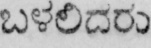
ಬಳಲಿದರು
